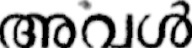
അവള്‍
